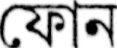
ফোন
